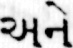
અને
